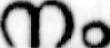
നം
